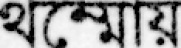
থম্মোয়
